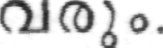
വരും.
